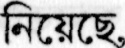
নিয়েছে,
